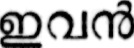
ഇവന്‍
